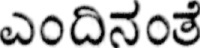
ಎಂದಿನಂತೆ
